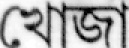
খোজা
